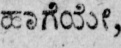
ಹಾಗೆಯೇ,
